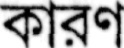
কারণ
